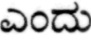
ಎಂದು
